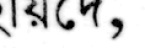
হায়দে,
